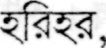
হরিহর,
